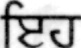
ਇਹ
